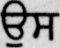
ਉਸ
